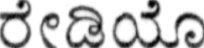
ರೇಡಿಯೊ
